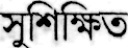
সুশিক্ষিত
